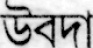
উবদা
